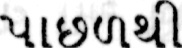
પાછળથી
